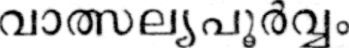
വാത്സല്യപൂര്‍വ്വം
